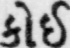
કોઈ
